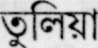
তুলিয়া
